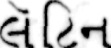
લૅટિન
